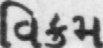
વિક્રમ
